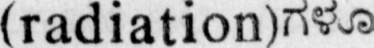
(radiation)ಗಳೂ
